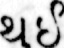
થઈ
